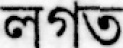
লগত
